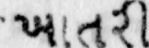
ખાતરી
